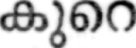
കുറെ
